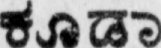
ಕೂಡಾ
